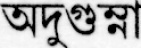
অদুগুম্না
